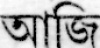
আজি
